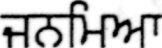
ਜਨਮਿਆ
